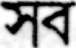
সব
